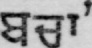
ਬਚਾ'
